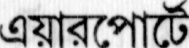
এয়ারপোর্টে
